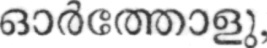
ഓര്‍ത്തോളു,
